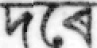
দৰে
